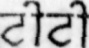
ਟੀਟੀ
